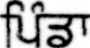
ਪਿੰਡਾ
